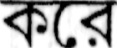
করে
